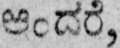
ಅಂದರೆ,
